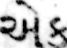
એક
